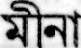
মীনা
